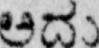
ಅದು
